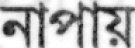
নাপায়
